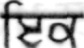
ਇਕ
